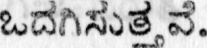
ಒದಗಿಸುತ್ತವೆ.
